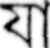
যা
